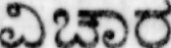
ವಿಚಾರ
